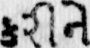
કરીને
